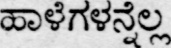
ಹಾಳೆಗಳನ್ನೆಲ್ಲ
